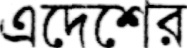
এদেশের
